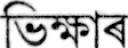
ভিক্ষাৰ
